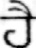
ਹੈ
